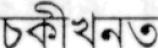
চকীখনত
